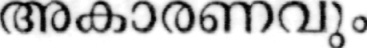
അകാരണവും
